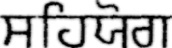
ਸਹਿਯੋਗ
